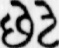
છેટે
